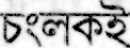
চংলকই
